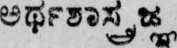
ಅರ್ಥಶಾಸ್ತ್ರಜ್ಞ
